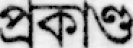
প্রকাণ্ড
